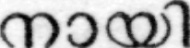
നായി
